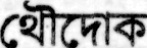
থৌদোক
